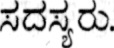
ಸದಸ್ಯರು.
